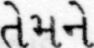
તેમને
